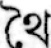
থৈ
